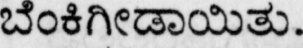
ಬೆಂಕಿಗೀಡಾಯಿತು.
